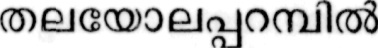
തലയോലപ്പറമ്പില്‍
